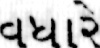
વધારે
